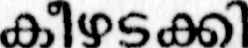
കീഴടക്കി
